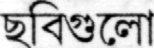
ছবিগুলো
